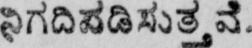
ನಿಗದಿಪಡಿಸುತ್ತವೆ.
